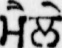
ਮੈਲੇ
